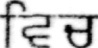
ਵਿਚ
